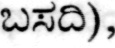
ಬಸದಿ),
